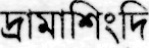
দ্রামাশিংদি
